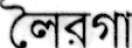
লৈরগা
